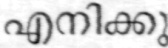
എനിക്കു
